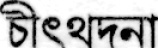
চীৎথদনা
